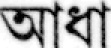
আধা
